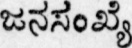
ಜನಸಂಖ್ಯೆ
